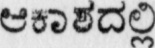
ಆಕಾಶದಲ್ಲಿ
